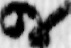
જ
